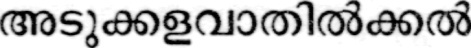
അടുക്കളവാതില്‍ക്കല്‍
